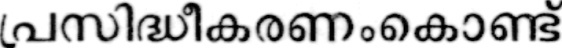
പ്രസിദ്ധീകരണംകൊണ്ട്
